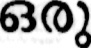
ഒരു
